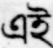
এই
